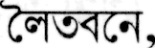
লৈতবনে,
